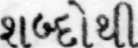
શબ્દોથી
